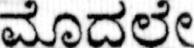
ಮೊದಲೇ
